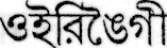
ওইরিঙৈগী
